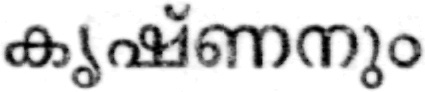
കൃഷ്ണനും
